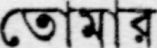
তোমার
